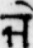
ਜੇ
